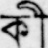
কী
